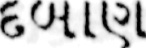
દબાણ
